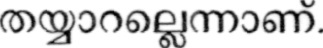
തയ്യാറല്ലെന്നാണ്.
